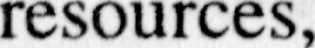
resources,
